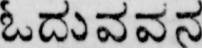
ಓದುವವನ
